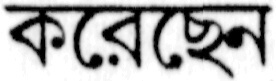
করেছেন
